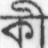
কী
